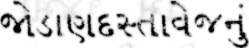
જોડાણદસ્તાવેજનું
